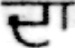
ਦਾ
